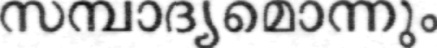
സമ്പാദ്യമൊന്നും
